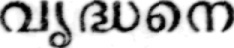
വൃദ്ധനെ
